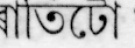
ৰাতিটো
